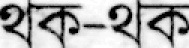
থক-থক
